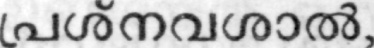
പ്രശ്നവശാല്‍,
